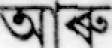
আৰু
